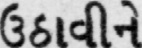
ઉઠાવીને
